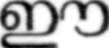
ഈ
